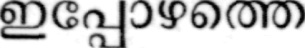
ഇപ്പോഴത്തെ
